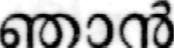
ഞാന്‍
